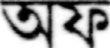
অফ
